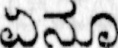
ಏನೂ
